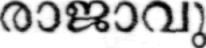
രാജാവു
